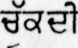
ਚੁੱਕਦੀ
